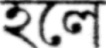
হলে
